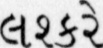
લશ્કરે
